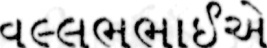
વલ્લભભાઈએ
